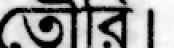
ফত্তবগা
